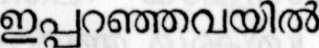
ഇപ്പറഞ്ഞവയില്‍
